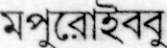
মপুরোইববু
